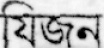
যিজন
